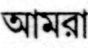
আমরা
